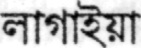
লাগাইয়া
